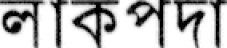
লাকপদা
